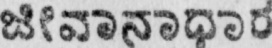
ಜೀವಾನಾಧಾರ
